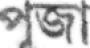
পূজা
